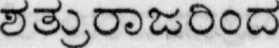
ಶತ್ರುರಾಜರಿಂದ
